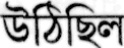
উঠিছিল
